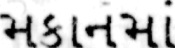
મકાનમાં
